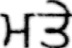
ਮਤੇ
